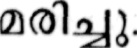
മരിച്ചു.
